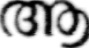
ആ
